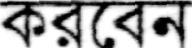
করবেন
